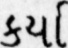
કર્યા
